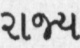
રાજ્ય
